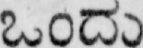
ಒಂದು
